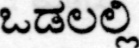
ಒಡಲಲ್ಲಿ
